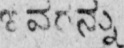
ಇವರನ್ನು
